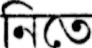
নিতে
